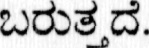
ಬರುತ್ತದೆ.
